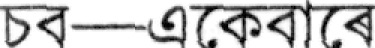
চব-একেবাৰে
